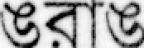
ঙরাঙ
